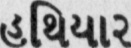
હથિયાર
